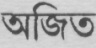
অজিত
